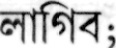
লাগিব;
